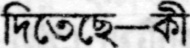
দিতেছে—কী
